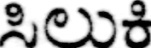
ಸಿಲುಕಿ
